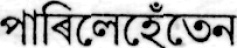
পাৰিলেহেঁতেন
